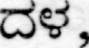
ದಳ,
